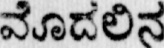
ಮೊದಲಿನ
